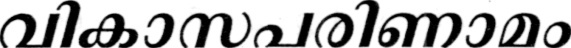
വികാസപരിണാമം
